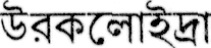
উরকলোইদ্রা
